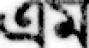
এম
